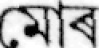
মোৰ
